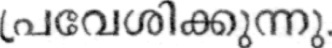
പ്രവേശിക്കുന്നു.
